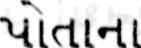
પોતાના
